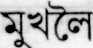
মুখলৈ
